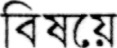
বিষয়ে
